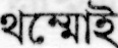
থম্মোই
